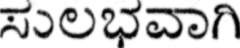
ಸುಲಭವಾಗಿ
